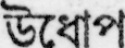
উধোপ
